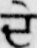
ਦੇ
